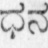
ಧನ
